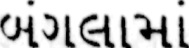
બંગલામાં
